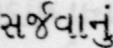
સર્જવાનું
